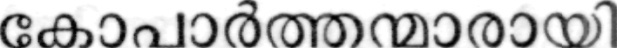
കോപാര്‍ത്തന്മാരായി
